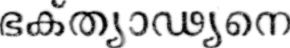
ഭക്ത്യാഢ്യനെ
